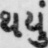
થયું
